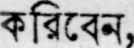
করিবেন,
